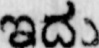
ಇದು
